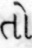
તો
